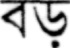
বড়
